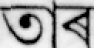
তাৰ
